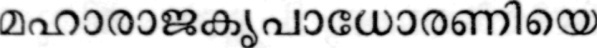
മഹാരാജകൃപാധോരണിയെ
